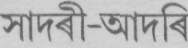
সাদৰী-আদৰি
